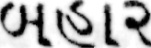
બહાર
